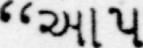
"આપ
